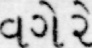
વગેરે
